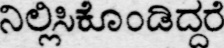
ನಿಲ್ಲಿಸಿಕೊಂಡಿದ್ದರೆ
